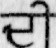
ਦੀ
